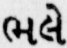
ભલે
